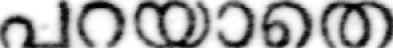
പറയാതെ
